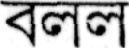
বলল
